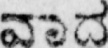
ವಾದ
